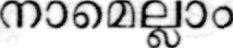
നാമെല്ലാം
